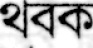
থবক
